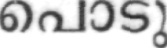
പൊടു
